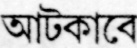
আটকাবে
